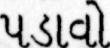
પડાવો
